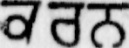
ਕਰਨ
